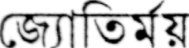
জ্যোতির্ময়
